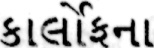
કાર્લોફના
